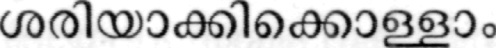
ശരിയാക്കിക്കൊള്ളാം
